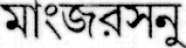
মাংজরসনু
